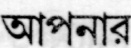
আপনার
